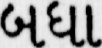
બધા
